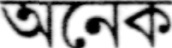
অনেক
